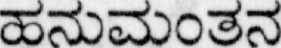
ಹನುಮಂತನ
